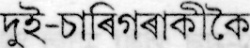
দুই-চাৰিগৰাকীকৈ
